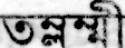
তম্লম্মী
